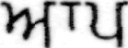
ਆਪ
